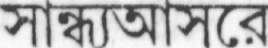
সান্ধ্যআসরে
